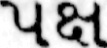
પક્ષ
